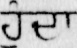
ਹੁੰਦਾ
